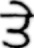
ਤੇ
